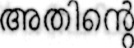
അതിന്റെ
